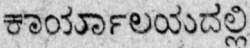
ಕಾರ್ಯಾಲಯದಲ್ಲಿ
